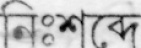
নিঃশব্দে
